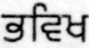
ਭਵਿਖ
